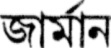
জার্মান
